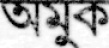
অমুক
